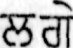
ਲਗੇ
